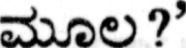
ಮೂಲ?’
